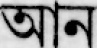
আন
